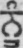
ਨੂੰ
